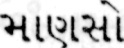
માણસો
